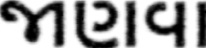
જાણવા
